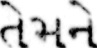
તેમને
